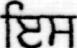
ਇਸ
